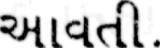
આવતી.
